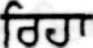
ਰਿਹਾ
